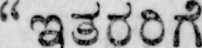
“ಇತರರಿಗೆ
